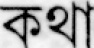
কথা
